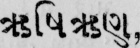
ઋષિઋણ,
